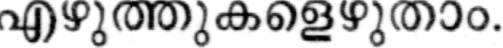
എഴുത്തുകളെഴുതാം.
